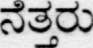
ನೆತ್ತರು
